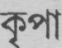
কৃপা
